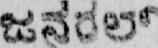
ಜನರಲ್
